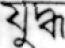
যুদ্ধ
